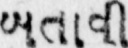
બતાવી
